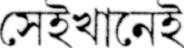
সেইখানেই
